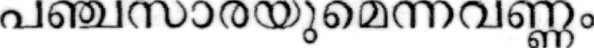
പഞ്ചസാരയുമെന്നവണ്ണം
